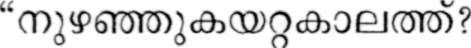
"നുഴഞ്ഞുകയറ്റകാലത്ത്?
